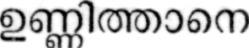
ഉണ്ണിത്താനെ
